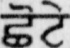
ਛੋਟੇ
